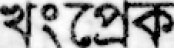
খংপ্রেক
